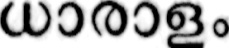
ധാരാളം
